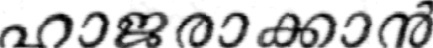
ഹാജരാക്കാന്‍
